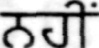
ਨਹੀਂ
